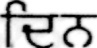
ਦਿਨ
